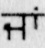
ਜਾਂ
